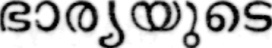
ഭാര്യയുടെ
